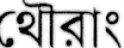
থৌরাং
